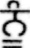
ਨੂੰ
